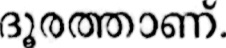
ദൂരത്താണ്.
